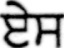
ਏਸ
